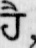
ਹੈ,
